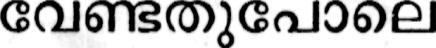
വേണ്ടതുപോലെ
